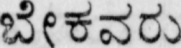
ಬೇಕವರು
